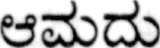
ಆಮದು
